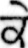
ਕੇ
